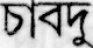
চাবদু
